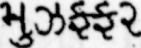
મુઝફ્ફર
